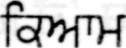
ਕਿਆਮ
